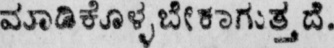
ಮಾಡಿಕೊಳ್ಳಬೇಕಾಗುತ್ತದೆ.
